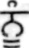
ਨੂੰ
